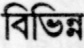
বিভিন্ন
